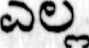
ಎಲ್ಲ
